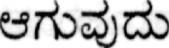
ಆಗುವುದು
